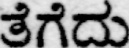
ತೆಗೆದು
